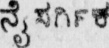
ನೈಸರ್ಗಿಕ
